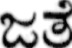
ಜತೆ
